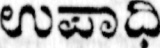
ಉಪಾಧಿ
